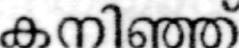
കനിഞ്ഞ്
